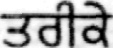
ਤਰੀਕੇ
